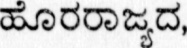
ಹೊರರಾಜ್ಯದ,
